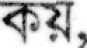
কয়,
